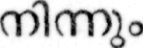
നിന്നും
